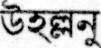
উহল্লনু
